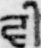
ਵੀ
